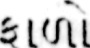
ફાળો
